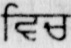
ਵਿਚ
